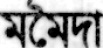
মমৈদা
